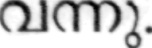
വന്നു.
